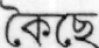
কৈছে
